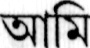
আমি
